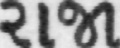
રાજા
